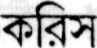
করিস
